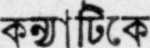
কন্যাটিকে
